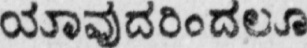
ಯಾವುದರಿಂದಲೂ
